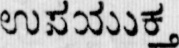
ಉಪಯುಕ್ತ
